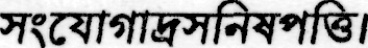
সংযোগাদ্রসনিষপত্তি।
